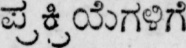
ಪ್ರಕ್ರಿಯೆಗಳಿಗೆ
